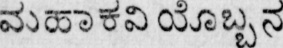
ಮಹಾಕವಿಯೊಬ್ಬನ
